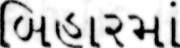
બિહારમાં
